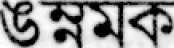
ঙম্নমক
